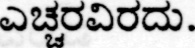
ಎಚ್ಚರವಿರದು.
